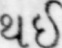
થઈ
